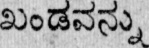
ಖಂಡವನ್ನು
